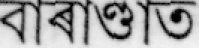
বাৰাণ্ডাত
